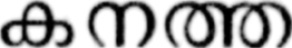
കനത്ത
